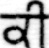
ਕੀ
